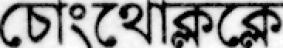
চোংথোক্লক্লে
